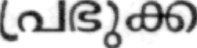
പ്രഭുക്ക
